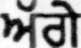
ਅੱਗੇ
